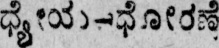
ಧ್ಯೇಯ-ಧೋರಣೆ
